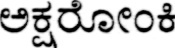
ಅಕ್ಷರೋಂಕಿ
